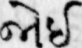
જોઈ
